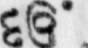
દઉં.
